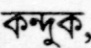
কন্দুক,
